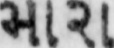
મારા
